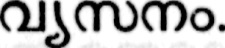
വ്യസനം.
